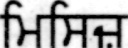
ਮਿਸਿਜ਼
